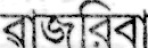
ৱাজরিবা
